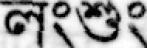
লংশুং
